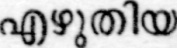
എഴുതിയ
